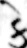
કે
